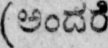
(ಅಂದರೆ
